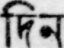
দিন
